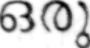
ഒരു
